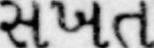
સખત
